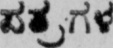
ಪತ್ರಗಳ
